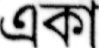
একা
